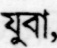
যুবা,
